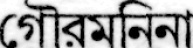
গৌরমনিনা
